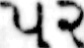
પર
